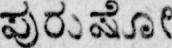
ಪುರುಷೋ
